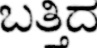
ಬತ್ತಿದ
